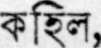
কহিল,
